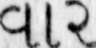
વાર
